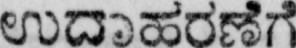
ಉದಾಹರಣೆಗೆ
